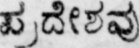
ಪ್ರದೇಶವು
